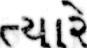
ત્યારે
